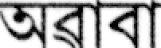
অৱাবা
